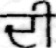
ਦੀ
